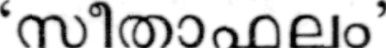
'സീതാഫലം'
